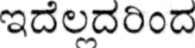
ಇದೆಲ್ಲದರಿಂದ
